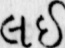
લઈ
